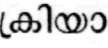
ക്രിയാ
